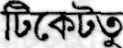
টিকেটতু
